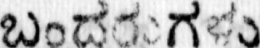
ಬಂದರುಗಳು
